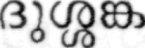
ദുശ്ശങ്ക
